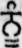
ਨੂੰ
